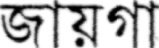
জায়গা
